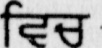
ਵਿਚ
